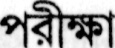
পরীক্ষা
